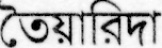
তৈয়ারিদা
